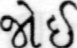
જોઈ
